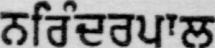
ਨਰਿੰਦਰਪਾਲ
